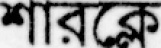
শারক্লে
